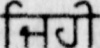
ਜਿਹੀ
